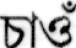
চাওঁ
